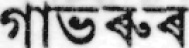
গাভৰুৰ
